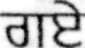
ਗਏ
